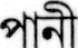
পানী
